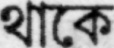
থাকে
